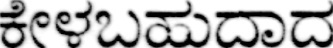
ಕೇಳಬಹುದಾದ
